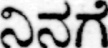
ನಿನಗೆ
